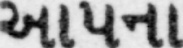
આપના
